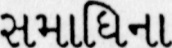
સમાધિના
